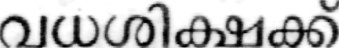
വധശിക്ഷക്ക്
